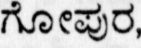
ಗೋಪುರ,
